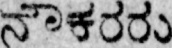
ನೌಕರರು
